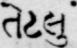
તેટલું
